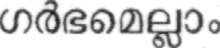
ഗര്‍ഭമെല്ലാം
